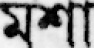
মশা
